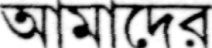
আমাদের
